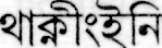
থাক্নীংইনি
